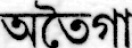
অতৈগা
